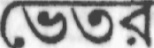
ভেতর
